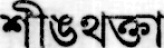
শীঙথক্তা
